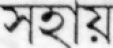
সহায়
